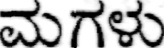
ಮಗಳು
